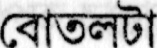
বোতলটা
